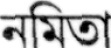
নমিতা
